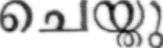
ചെയ്തു
